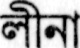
লীনা
